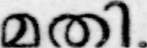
മതി.
